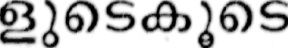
ളുടെകൂടെ
